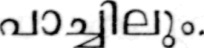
പാച്ചിലും.
